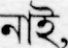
নাই,
